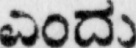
ಎಂದು
